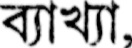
ব্যাখ্যা,
